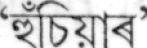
'হুঁচিয়াৰ'
